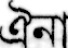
ঐনা
